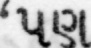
'પણ
